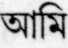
আমি
